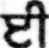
ਈ
